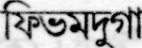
ফিভমদুগা
